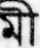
মী
